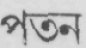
পতন
